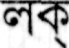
লক্
